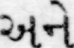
અને
